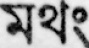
মথং
